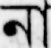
না
